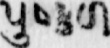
પુષ્કળ
